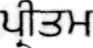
ਪ੍ਰੀਤਮ
